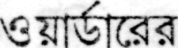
ওয়ার্ডারের
